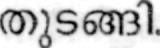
തുടങ്ങി.
